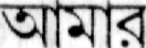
আমার
